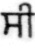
ਸੀ
